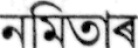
নমিতাৰ
